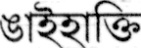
ঙাইহাক্তি
